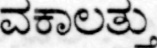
ವಕಾಲತ್ತು
